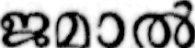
ജമാല്‍
